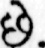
છે.
